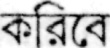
করিবে
